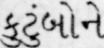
કુટુંબોને
